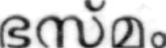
ഭസ്മം
